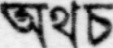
অথচ
